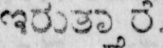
ಇರುತ್ತಾರೆ.
